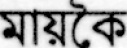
মায়কৈ
